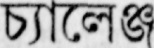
চ্যালেঞ্জ
